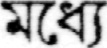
মধ্যে
